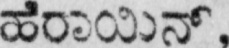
ಹೆರಾಯಿನ್,
